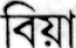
বিয়া
